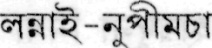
লন্নাই-নুপীমচা
